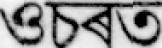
ওচৰত
